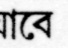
যাবে
